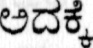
ಅದಕ್ಕೆ
